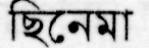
ছিনেমা
